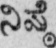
ನಿಷ್ಠೆ
